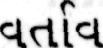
વર્તાવ
